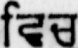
ਵਿਚ
